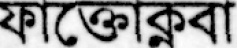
ফাক্তোক্নবা
